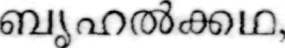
ബൃഹല്‍ക്കഥ,
